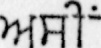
ਅਸੀਂ
